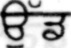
ਉੱਡ
